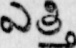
ಎತ್ತಿ
